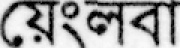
য়েংলবা
